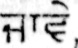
ਜਾਵੇ,
